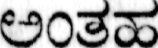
ಅಂತಹ
